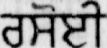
ਰਸੋਈ
